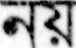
নয়
